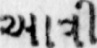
આવી
